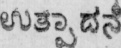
ಉತ್ಪಾದನೆ
